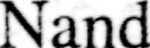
Nand
